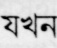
যখন
